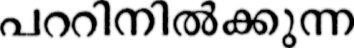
പററിനില്‍ക്കുന്ന
